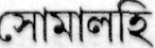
সোমালহি
